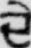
ਦੇ
